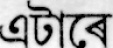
এটাৰে
